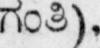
ಗಂತಿ),
